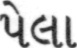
પેલા
